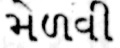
મેળવી
